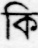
কি
